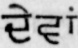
ਦੇਵਾਂ
